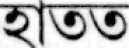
হাতত
